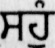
ਸਹੁੰ
